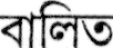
বালিত
